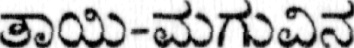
ತಾಯಿ-ಮಗುವಿನ
